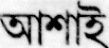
আশাই
